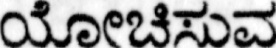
ಯೋಚಿಸುವ
